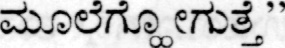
ಮೂಲೆಗ್ಹೋಗುತ್ತೆ"
